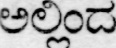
ಅಲ್ಲಿ೦ದ
